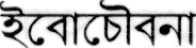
ইবোচৌবনা
